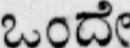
ಒಂದೇ
